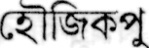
হৌজিকপু
